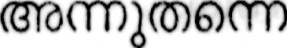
അന്നുതന്നെ
